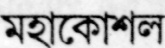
মহাকোশল
